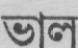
ভাল
